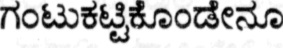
ಗಂಟುಕಟ್ಟಿಕೊಂಡೇನೂ
